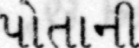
પોતાની
